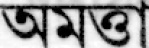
অমত্তা
